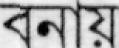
বনায়
